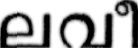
ലവീ
